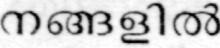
നങ്ങളില്‍
